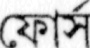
ফোর্স
